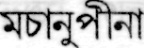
মচানুপীনা
